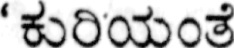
'ಕುರಿಯಂತೆ
